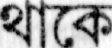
থাকে
